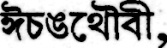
ঈচঙথৌবী,
